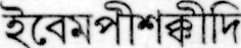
ইবেমপীশক্কীদি
